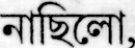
নাছিলো,
